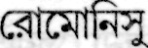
রোমোনিসু
